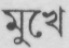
মুখে
